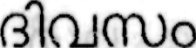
ദിവസം
